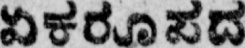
ಏಕರೂಪದ
